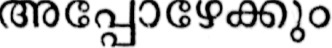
അപ്പോഴേക്കും
